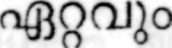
ഏറ്റവും
